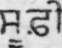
ਸੂਫ਼ੀ
